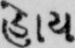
હોય
